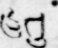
હતુ
